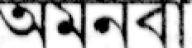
অমনবা
